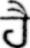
ਹੈ
